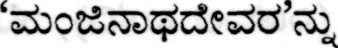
‘ಮಂಜಿನಾಥದೇವರ’ನ್ನು
